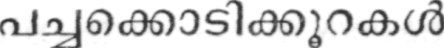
പച്ചക്കൊടിക്കൂറകള്‍
